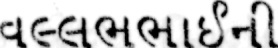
વલ્લભભાઈની
